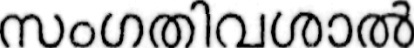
സംഗതിവശാല്‍
